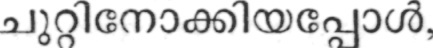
ചുറ്റിനോക്കിയപ്പോള്‍,
